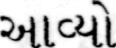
આવ્યો
